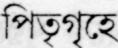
পিতৃগৃহে
